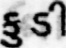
કુડી
